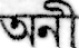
অনী
